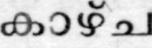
കാഴ്ച
